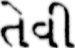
તેવી
